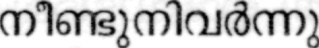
നീണ്ടുനിവര്‍ന്നു
